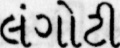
લંગોટી
